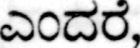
ಎಂದರೆ,
